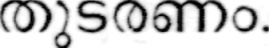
തുടരണം.
